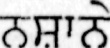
ਨਸ਼ਾਨੇ
